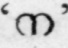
‘ന’
